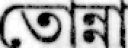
তোন্না
